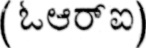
(ಓಆರ್ ಐ)
